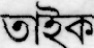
তাইক
